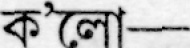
ক'লো-
